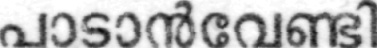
പാടാന്‍വേണ്ടി
